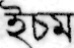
ইচম
